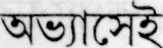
অভ্যাসেই
